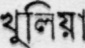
খুলিয়া
